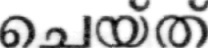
ചെയ്ത്
